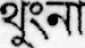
থুংনা
